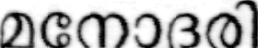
മനോദരി
